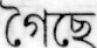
গৈছে
